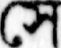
সে
